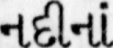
નદીનાં
